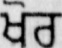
ਖੋਰ
